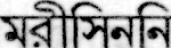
মরীসিননি
